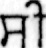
ਸੀ
